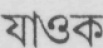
যাওক
